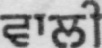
ਵਾਲੀ
